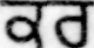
ਕਰ
